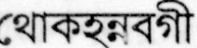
থোকহন্নবগী
